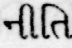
નીતિ
